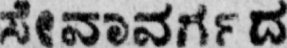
ಸೇವಾವರ್ಗದ
